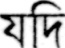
যদি
